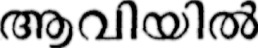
ആവിയില്‍
